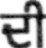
ਦੀ
